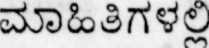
ಮಾಹಿತಿಗಳಲ್ಲಿ
